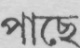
পাছে
